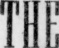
THE
